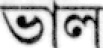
ভাল
